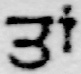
ਤਾਂ
